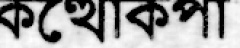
কত্থোকপা
